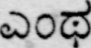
ಎಂಥ
